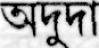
অদুদা
